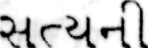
સત્યની
